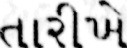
તારીખે
